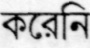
করেনি
